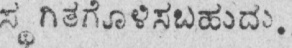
ಸ್ಥಗಿತಗೊಳಿಸಬಹುದು.
